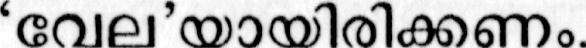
‘വേല’യായിരിക്കണം.
